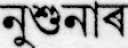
নুশুনাৰ
